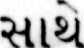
સાથે
